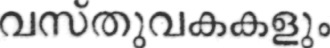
വസ്തുവകകളും
